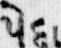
પેદા
